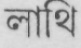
লাথি
